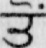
ਤੋਂ
